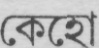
কেহো
